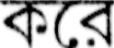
করে
